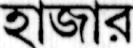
হাজার
